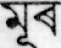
মূৰ
